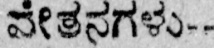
ವೇತನಗಳು--
